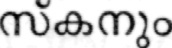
സ്കനും
